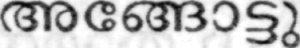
അങ്ങോട്ടു
